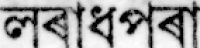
লৰাধপৰা
